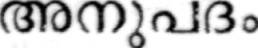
അനുപദം
